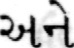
અને
